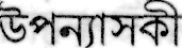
উপন্যাসকী
